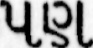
પણ
